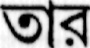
তার
